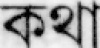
কথা
